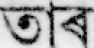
তাৰ
